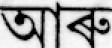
আৰু
